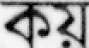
কয়
